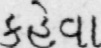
કહેવા
